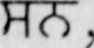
ਸਨ,
